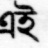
এই
